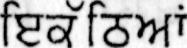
ਇਕੱਠਿਆਂ
